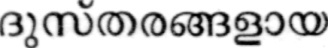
ദുസ്തരങ്ങളായ
